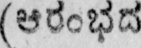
(ಆರಂಭದ
